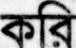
করি
